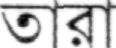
তারা
